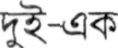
দুই-এক
